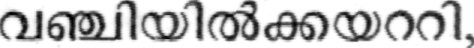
വഞ്ചിയില്‍ക്കയററി,
